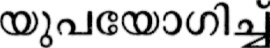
യുപയോഗിച്ച്
